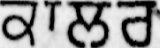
ਕਾਲਰ
